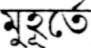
মুহূর্তে
